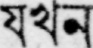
যখন
